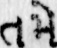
તમે
